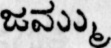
ಜಮ್ಮು
